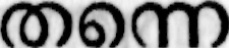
തന്നെ
